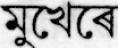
মুখেৰে
